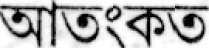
আতংকত
